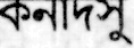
কনাদসু
